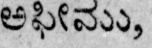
ಅಫೀಮು,
